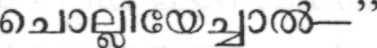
ചൊല്ലിയേച്ചാല്‍-"
